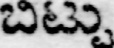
ಬಿಟ್ಟು
